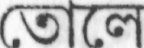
তোলে
